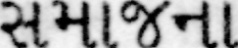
સમાજના
